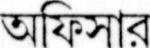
অফিসার
